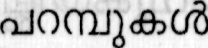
പറമ്പുകള്‍
